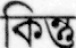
কিন্তু
